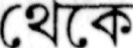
থেকে
